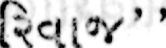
રિવાજ"
